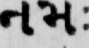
નમઃ
